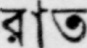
রাত
